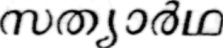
സത്യാര്‍ഥ
